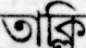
তাক্লি
